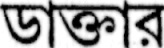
ডাক্তার
